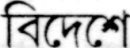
বিদেশে
